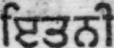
ਇਤਨੀ
